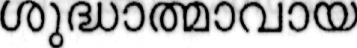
ശുദ്ധാത്മാവായ
